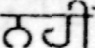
ਨਹੀਂ
